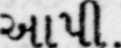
આપી.
